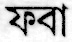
ফবা
